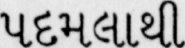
પદમલાથી
